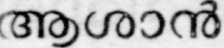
ആശാന്‍
